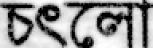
চৎলো
